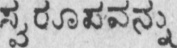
ಸ್ವರೂಪವನ್ನು
